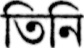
তিনি
